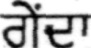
ਗੇਂਦਾ
